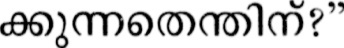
ക്കുന്നതെന്തിന്?”
